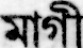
মাগী
